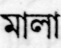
মালা
